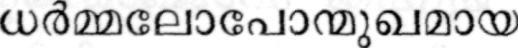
ധര്‍മ്മലോപോന്മുഖമായ
